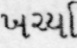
ખર્ચ્યા
